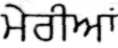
ਮੇਰੀਆਂ
